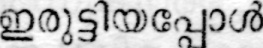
ഇരുട്ടിയപ്പോള്‍
